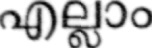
എല്ലാം
